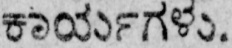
ಕಾರ್ಯಗಳು.
